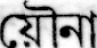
য়ৌনা
